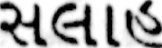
સલાહ
